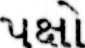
પક્ષો
